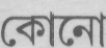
কোনো
